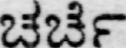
ಚರ್ಚೆ
